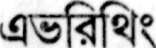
এভরিথিং
